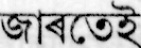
জাৰতেই
